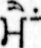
ਮੈਂ
